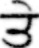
ਤੇ
